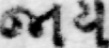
જાય
